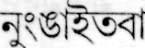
নুংঙাইতবা
